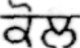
ਕੋਲ
